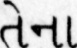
તેના
